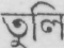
তুলি
